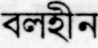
বলহীন
